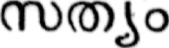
സത്യം
